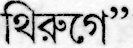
থিরুগে”
